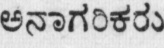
ಅನಾಗರಿಕರು
